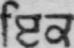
ਇਕ
